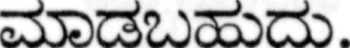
ಮಾಡಬಹುದು.
